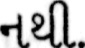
નથી.
